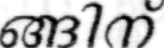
ങ്ങിന്
